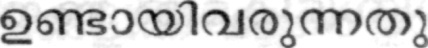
ഉണ്ടായിവരുന്നതു
